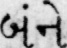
બંને
